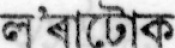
ল'ৰাটোক
